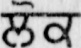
ਲੋਕ
